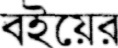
বইয়ের
